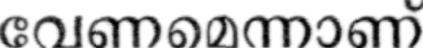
വേണമെന്നാണ്
